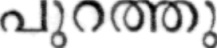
പുറത്തു
